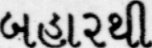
બહારથી
